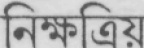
নিক্ষত্ৰিয়
